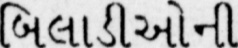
બિલાડીઓની
